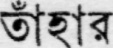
তাঁহার
